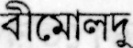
বীমোলদু
